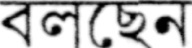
বলছেন
